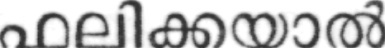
ഫലിക്കയാല്‍
